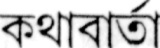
কথাবার্তা
